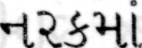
નરકમાં
